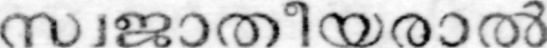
സ്വജാതീയരാല്‍
